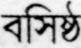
বসিষ্ঠ
